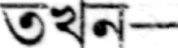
তখন-
